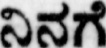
ನಿನಗೆ
